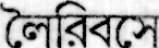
লৈরিবসে
